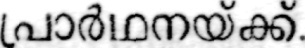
പ്രാര്‍ഥനയ്ക്ക്.
